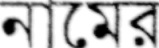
নামের
